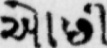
ઓછી
